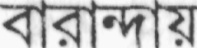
বারান্দায়
